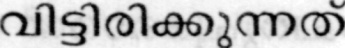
വിട്ടിരിക്കുന്നത്
